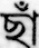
ছাঁ
